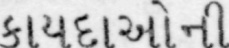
કાયદાઓની
